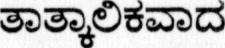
ತಾತ್ಕಾಲಿಕವಾದ
